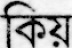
কিয়
